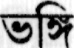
ভঙ্গি
